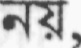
নয়,
